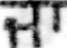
ਜਾ
